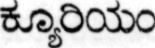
ಕ್ಯೂರಿಯಂ
